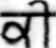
ਕੀ
